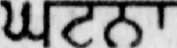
ਘਟਨਾ
